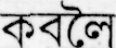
কবলৈ
